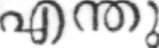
എന്തു
